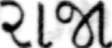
રાજા
